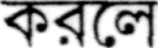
করলে
